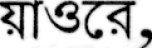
য়াওরে,
